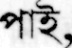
পাই,
